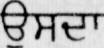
ਉਸਦਾ
